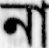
না
